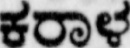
ಕರಾಳ
